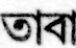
তাবা
